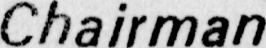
Chairman
